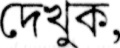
দেখুক,
